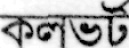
করভর্ট
